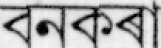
বনকৰা
